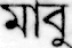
মাবু
